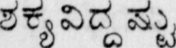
ಶಕ್ಯವಿದ್ದಷ್ಟು
